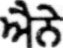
ਐਨੇ
